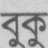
বুকু
